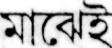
মাঝেই
